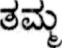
ತಮ್ಮ
